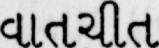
વાતચીત
